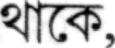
থাকে,
